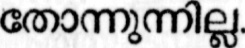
തോന്നുന്നില്ല.
